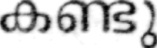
കണ്ടു
